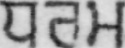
ਧਰਮ
